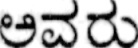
ಅವರು
